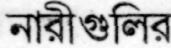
নারীগুলির
